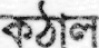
কঠাল
